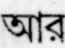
আর
